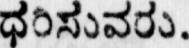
ಧರಿಸುವರು.
